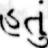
હતું
